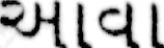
આવા
